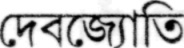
দেবজ্যোতি
